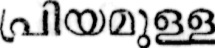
പ്രിയമുള്ള
